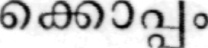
ക്കൊപ്പം
